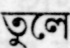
তুলে
